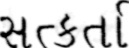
સત્કર્તા
